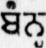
ਬੰਨ੍ਹ
